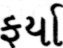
ફર્યા
